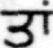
ਤਾਂ
